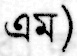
এম)
